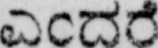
ಎಂದರೆ
